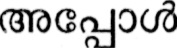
അപ്പോള്‍
